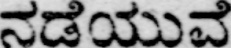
ನಡೆಯುವೆ
